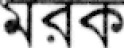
মরক
